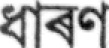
ধাৰণ
